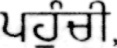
ਪਹੁੰਚੀ,
